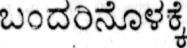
ಬಂದರಿನೊಳಕ್ಕೆ
